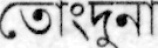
তোংদুনা
